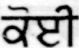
ਕੋਈ
